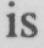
is
